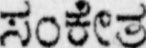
ಸಂಕೇತ
